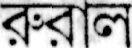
রুরাল
